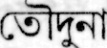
তৌদুনা
